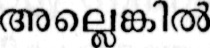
അല്ലെങ്കില്‍
